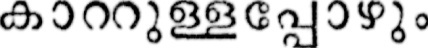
കാററുള്ളപ്പോഴും
